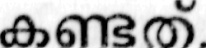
കണ്ടത്.
